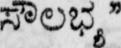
ಸೌಲಭ್ಯ”
